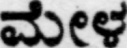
ಮೇಳ
